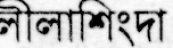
লীলাশিংদা
